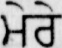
ਮੇਰੇ
